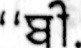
''ਬੀ.
